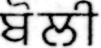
ਬੋਲੀ
